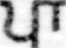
ਪਾ
